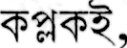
কপ্লকই,
